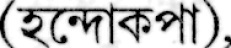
(হন্দোকপা),
